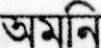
অমনি
